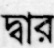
দ্বার
